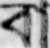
বা
